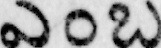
ಎಂಬ
